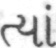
ત્યાં
